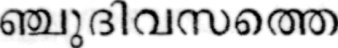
ഞ്ചുദിവസത്തെ
